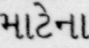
માટેના
